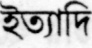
ইত্যাদি
